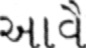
આવૈ
